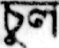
চুল
